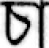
চা
